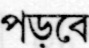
পড়বে
